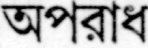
অপরাধ
